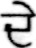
ਦੇ
